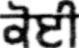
ਕੋਈ
